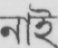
নাই
